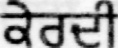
ਕੇਰਦੀ
